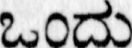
ಒಂದು
